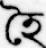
হৈ
